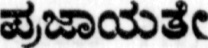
ಪ್ರಜಾಯತೇ
